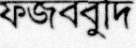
ফজববুদি
